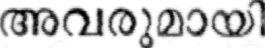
അവരുമായി
